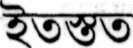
ইতস্তত
